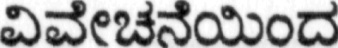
ವಿವೇಚನೆಯಿಂದ
